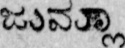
ಜುಮ್ಲಾ
